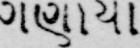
ગણાયા
